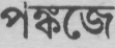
পঙ্কজে
